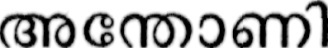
അന്തോണി
